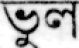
ভুল
